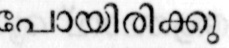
പോയിരിക്കു
